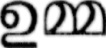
ഉമ്മ
